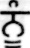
ਨੂੰ
